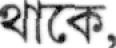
থাকে,
